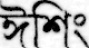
ঈশিং
